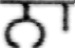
ਨਾ
